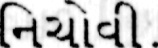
નિચોવી.
